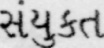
સંયુક્ત
